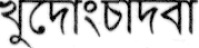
খুদোংচাদবা
